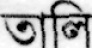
তালি
